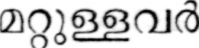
മറ്റുള്ളവര്‍
